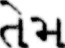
તેમ
